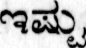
ಇಷ್ಟು
